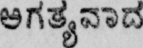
ಅಗತ್ಯವಾದ
